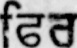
ਫਿਰ
